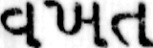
વખત
